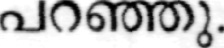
പറഞ്ഞു.
